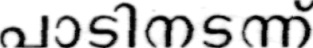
പാടിനടന്ന്
